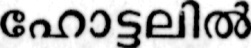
ഹോട്ടലില്‍
